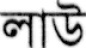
লাউ
